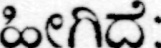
ಹೀಗಿದೆ:
